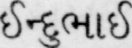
ઈન્દુભાઈ
